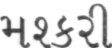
મશ્કરી
